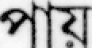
পায়
